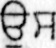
ਉਸ
